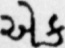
એક
